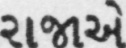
રાજાએ
